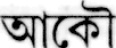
আকৌ
